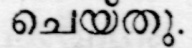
ചെയ്തു.
